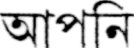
আপনি
